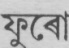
ফুৰো
